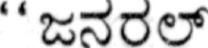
"ಜನರಲ್
